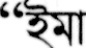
“ইমা
